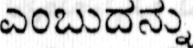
ಎಂಬುದನ್ನು
